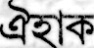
ঐহাক
